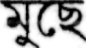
মুছে
